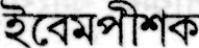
ইবেমপীশক
